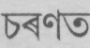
চৰণত
